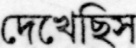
দেখেছিস
